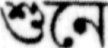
শুনে
